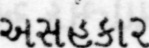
અસહકાર
